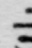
ਤ
